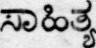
ಸಾಹಿತ್ಯ
